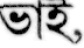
ভাই,
